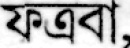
ফত্রবা,
